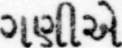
ગણીએ
